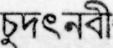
চুদৎনবী
